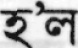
হ'ল
